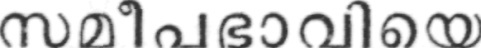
സമീപഭാവിയെ
